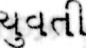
યુવતી
